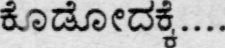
ಕೊಡೋದಕ್ಕೆ..
